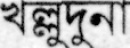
খল্লুদুনা
